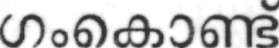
ഗംകൊണ്ട്
